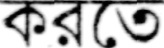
করতে
